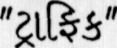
"ટ્રાફિક"
